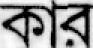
কার
